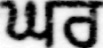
ਘਰ
